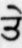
ਤੇ
